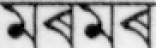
মৰমৰ
